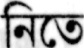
নিতে
